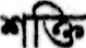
শক্তি
